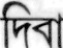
দিবা
